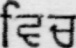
ਵਿਚ
